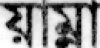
য়াম্না
